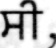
ਸੀ,
